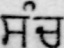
ਸੰਚ
